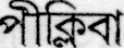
পীক্লিবা
